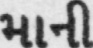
માની
